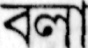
বলা
